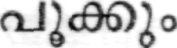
പൂക്കും
